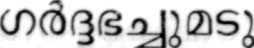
ഗര്‍ദ്ദഭച്ചുമടു
